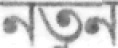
নতুন
